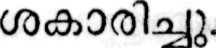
ശകാരിച്ചു.
